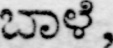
ಬಾಳೆ,
